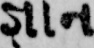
જ્ઞાન
